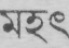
মহৎ
